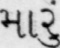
મારું
